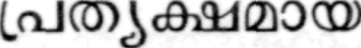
പ്രത്യക്ഷമായ
